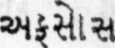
અફસોસ
